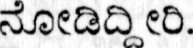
ನೋಡಿದ್ದೀರಿ.
